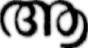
ആ
